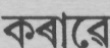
কৰাৱে
